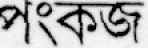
পংকজ
